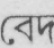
বেদ
